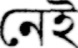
নেই
